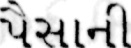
પૈસાની
